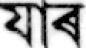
যাৰ
